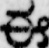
ಈ
